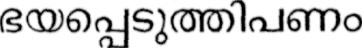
ഭയപ്പെടുത്തിപണം
